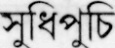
সুধিপুচি
